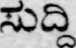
ಸುದ್ದಿ
